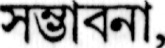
সম্ভাবনা,
